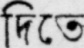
দিতে
